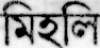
মিহলি
